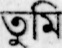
তুমি
